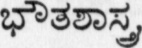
ಭೌತಶಾಸ್ತ್ರ,
